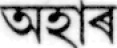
অহাৰ
